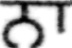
ਨਾ
